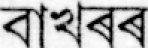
বাখৰৰ
